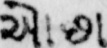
ઓછા
